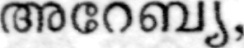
അറേബ്യ,
